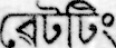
ৱেটটিং
